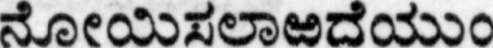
ನೋಯಿಸಲಾಱದೆಯುಂ
